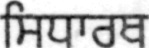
ਸਿਧਾਰਥ
